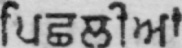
ਪਿਛਲੀਆਂ
